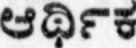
ಆರ್ಥಿಕ
